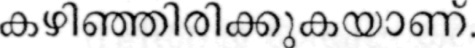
കഴിഞ്ഞിരിക്കുകയാണ്.
